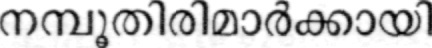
നമ്പൂതിരിമാര്‍ക്കായി
